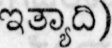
ಇತ್ಯಾದಿ)
